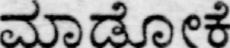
ಮಾಡೋಕೆ
